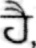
ਹੈ,
